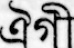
ঐগী
